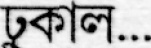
ঢুকাল...
